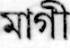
মাগী
